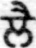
ਲੈ
